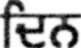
ਦਿਨ
